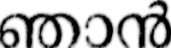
ഞാന്‍
